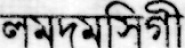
লমদমসিগী
